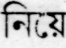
নিয়ে
